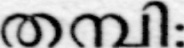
തമ്പി:
